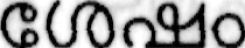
ശേഷം
